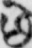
છે
